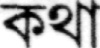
কথা
